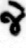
જે
